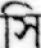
সি
